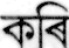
কৰি
